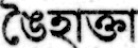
ঙৈহাক্তা
